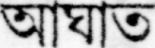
আঘাত
